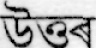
উত্তৰ
